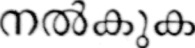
നല്‍കുക
